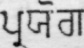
ਪ੍ਰਯੋਗ
